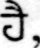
ਹੈ,
